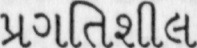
પ્રગતિશીલ
